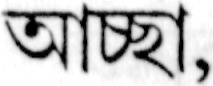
আচ্ছা,
